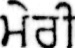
ਮੇਰੀ
